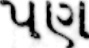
પણ
